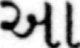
આ
